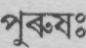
পুৰুষঃ
